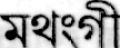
মথংগী
